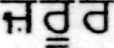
ਜ਼ਰੂਰ
